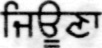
ਜਿਊਣਾ
